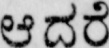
ಆದರೆ
